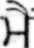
ਮੈਂ
